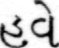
હવે
